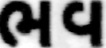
ભવ
